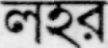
লহর
